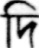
দি
